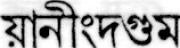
য়ানীংদগুম
